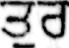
ਤੁਰ
